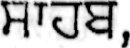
ਸਾਹਬ,
